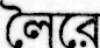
লৈরে
